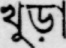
খুড়া
